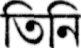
তিনি
